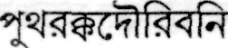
পুথরক্কদৌরিবনি
